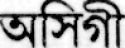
অসিগী
